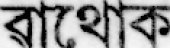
ৱাথোক
